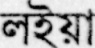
লইয়া
